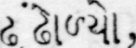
ઢંઢોળ્યો,
